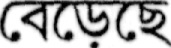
বেড়েছে
